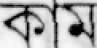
কাম
